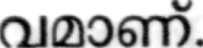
വമാണ്.
